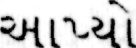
આપ્યો
